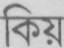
কিয়
